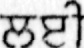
ਲਈ
